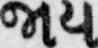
જાય
